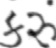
કરું
